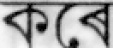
কৰে
